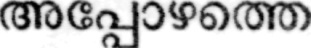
അപ്പോഴത്തെ
